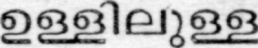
ഉള്ളിലുള്ള
